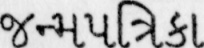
જન્મપત્રિકા
